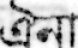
ঐনা
